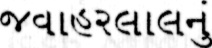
જવાહરલાલનું
